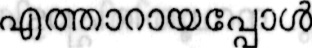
എത്താറായപ്പോള്‍
